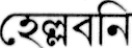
হেল্লবনি
